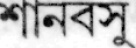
শানবসু
